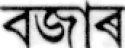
বজাৰ
